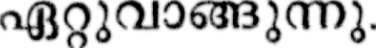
ഏറ്റുവാങ്ങുന്നു.
